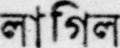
লাগিল
